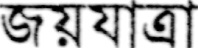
জয়যাত্রা
